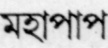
মহাপাপ
